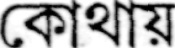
কোথায়
